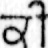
ਕੀ
